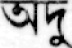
অদু
